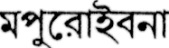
মপুরোইবনা
